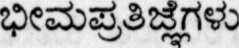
ಭೀಮಪ್ರತಿಜ್ಞೆಗಳು
